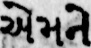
એમને
